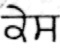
ਕੇਸ
